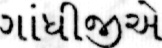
ગાંધીજીએ
